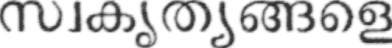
സ്വകൃത്യങ്ങളെ
